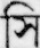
সি
